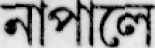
নাপালে
